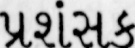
પ્રશંસક
